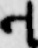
ન
